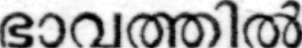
ഭാവത്തില്‍
